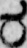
ರ
